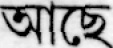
আছে
